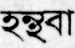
হন্থবা
